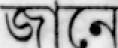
জানে
